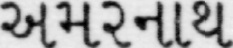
અમરનાથ
